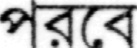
পরবে
